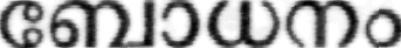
ബോധനം
